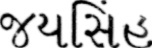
જયસિંહ
